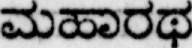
ಮಹಾರಥ
